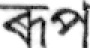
ৰূপ
